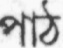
পাঠ
